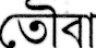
তৌবা
